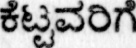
ಕೆಟ್ಟವರಿಗೆ
